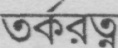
তর্করত্ন
